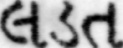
લડત
